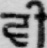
ਵੀ
